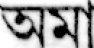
অমা
